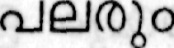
പലരും
